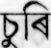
চুৰি
